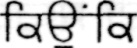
ਕਿਉਂਕਿ
